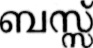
ബസ്സ്
